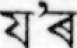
য'ৰ
